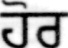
ਹੋਰ
